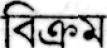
বিক্রম
